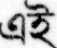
এই
